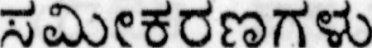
ಸಮೀಕರಣಗಳು
